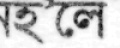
নহ'লে
